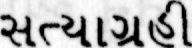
સત્યાગ્રહી
